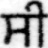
ਸੀ
